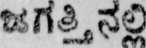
ಜಗತ್ತಿನಲ್ಲಿ
